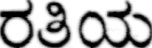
ರತಿಯ
